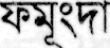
ফমূংদা
